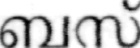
ബസ്
